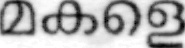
മകളെ
